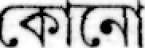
কোনো
